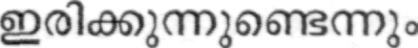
ഇരിക്കുന്നുണ്ടെന്നും
